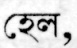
হেল,
